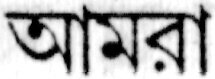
আমরা
